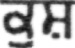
ਕੁਸ਼
